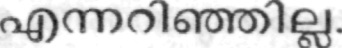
എന്നറിഞ്ഞില്ല.
